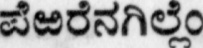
ಪೆಱರೆನಗಿಲ್ಲೆಂ
